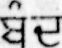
ਬੰਦ
